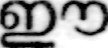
ഈ
